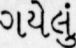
ગયેલું
